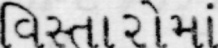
વિસ્તારોમાં
